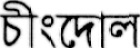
চীংদোল
